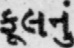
ફૂલનું
